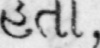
હતા,
